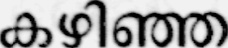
കഴിഞ്ഞ
